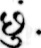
છું.
